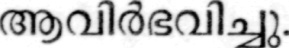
ആവിര്‍ഭവിച്ചു.
